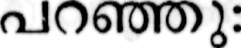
പറഞ്ഞു:
